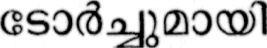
ടോര്‍ച്ചുമായി
